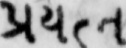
પ્રયત્ન
